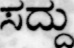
ಸದ್ದು
